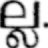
ല്ല.
